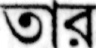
তার
